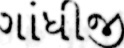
ગાંધીજી
